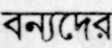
বন্যদের
